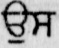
ਉਸ
